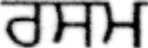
ਰਸਮ
